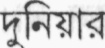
দুনিয়ার
